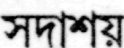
সদাশয়
